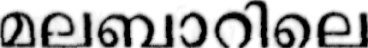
മലബാറിലെ
